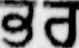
ਭਰ
